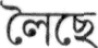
লৈছে
